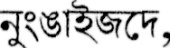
নুংঙাইজদে,
